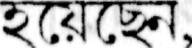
হয়েছেন,
